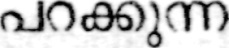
പറക്കുന്ന
